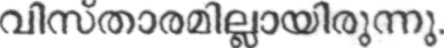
വിസ്താരമില്ലായിരുന്നു.
